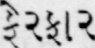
ફેરફાર
